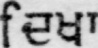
ਦਿਖਾ
